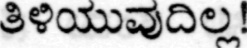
ತಿಳಿಯುವುದಿಲ್ಲ!
